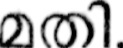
മതി.
